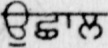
ਉਛਾਲ
